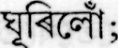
ঘূৰিলোঁ;
